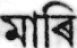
মাৰি
